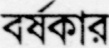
বর্ষকার
